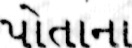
પોતાના
